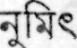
নুমিৎ
